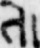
તો
